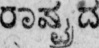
ರಾಷ್ಟ್ರದ
